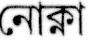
নোক্না
